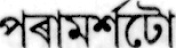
পৰামর্শটো
